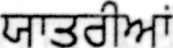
ਯਾਤਰੀਆਂ
